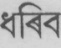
ধৰিব
